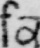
ਕਿ
